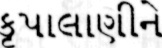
કૃપાલાણીને
